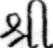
શ્રી
